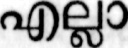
എല്ലാ
